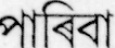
পাৰিবা
